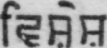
ਵਿਸ਼ੇਸ਼
